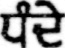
ਧੰਦੇ
